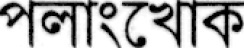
পলাংখোক
